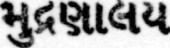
મુદ્રણાલય
